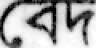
বেদ
